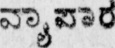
ವ್ಯಾಪಾರ
